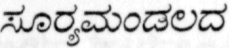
ಸೂರ್‍ಯಮಂಡಲದ
